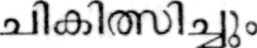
ചികിത്സിച്ചും
